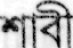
শাবী
